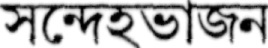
সন্দেহভাজন
